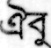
ঐবু
